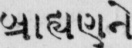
બ્રાહ્યણને
